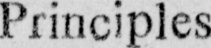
Principles
